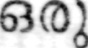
ഒരു
